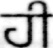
ਹੀ
